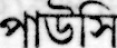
পাউসি
